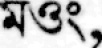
মওং,
